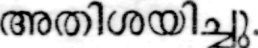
അതിശയിച്ചു.
